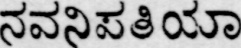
ನವನಿಪತಿಯಾ
